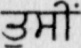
ਤੁਸੀਂ
